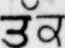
ਤੱਕ
